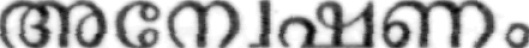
അന്വേഷണം
